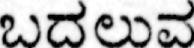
ಬದಲುವ
